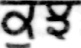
ਕੁਝ
